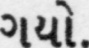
ગયો.
